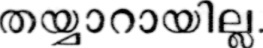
തയ്യാറായില്ല.
